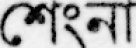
শেংনা
